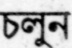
চলুন
